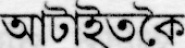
আটাইতকৈ
